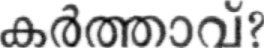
കര്‍ത്താവ്?
